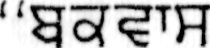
''ਬਕਵਾਸ
